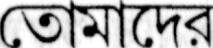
তোমাদের
